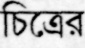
চিত্রের
